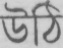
উঠি
